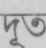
দূত
